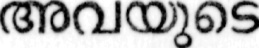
അവയുടെ
